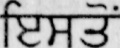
ਇਸਤੋਂ
